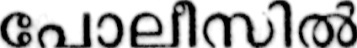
പോലീസില്‍
